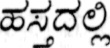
ಹಸ್ತದಲ್ಲಿ
